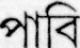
পাবি
